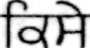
ਕਿਸੇ
